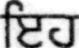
ਇਹ
